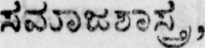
ಸಮಾಜಶಾಸ್ತ್ರ,
